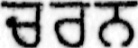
ਚਰਨ
